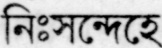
নিঃসন্দেহে
